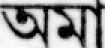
অমা
